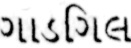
ગાડગિલ
